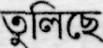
তুলিছে
